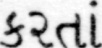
કરતાં
